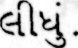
લીધું.
